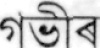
গভীৰ
